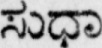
ಸುಧಾ
